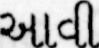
આવી
